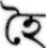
হৈ
